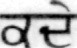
ਕਦੇ
